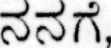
ನನಗೆ,
